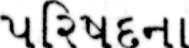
પરિષદના
